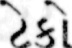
ટેકો
